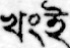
খংই
